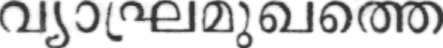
വ്യാഘ്രമുഖത്തെ
